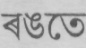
ৰঙতে
